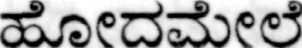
ಹೋದಮೇಲೆ
